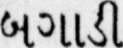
બગાડી
